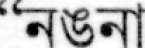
“নঙনা
